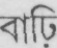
বাঢ়ি
